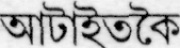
আটাইতকৈ
